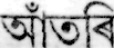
আঁতৰি
